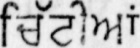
ਚਿੱਟੀਆਂ
